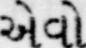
એવો
